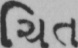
ચિત
